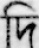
দি
